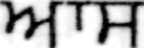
ਆਸ
